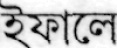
ইফালে
